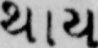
થાય
